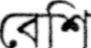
বেশি
